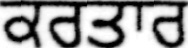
ਕਰਤਾਰ
